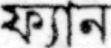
ফ্যান
